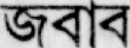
জবাব
